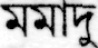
মমাদু
